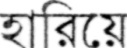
হারিয়ে
